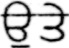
ਉਤੇ
